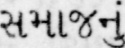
સમાજનું
